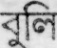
বুলি
